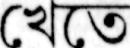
খেতে
